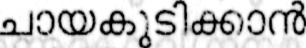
ചായകുടിക്കാന്‍
